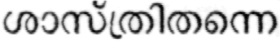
ശാസ്ത്രിതന്നെ
